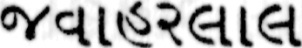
જવાહરલાલ
